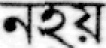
নহয়
